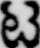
ಟ
